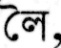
লৈ,
